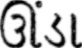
ઊંડા
